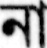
না
